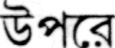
উপরে
